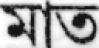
মাত
